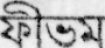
ফীভম
